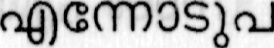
എന്നോടുപ
